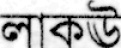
লাকউ
